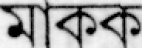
মাকক
